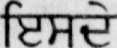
ਇਸਦੇ
